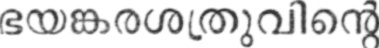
ഭയങ്കരശത്രുവിന്റെ
